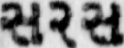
સરસ
